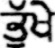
ਭੁੱਖੇ
